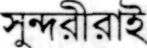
সুন্দরীরাই
